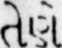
તેણે
